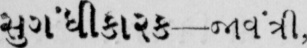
સુગંધીકારક-જવંત્રી,
